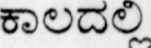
ಕಾಲದಲ್ಲಿ
